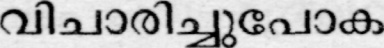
വിചാരിച്ചുപോക
